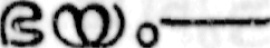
ഭയം-
